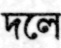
দলে
